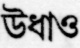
উধাও
